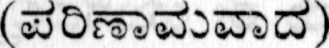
(ಪರಿಣಾಮವಾದ)
